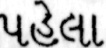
પહેલા
